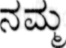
ನಮ್ಮ
